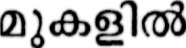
മുകളില്‍
